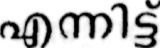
എന്നിട്ട്
